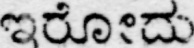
ಇರೋದು
